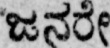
ಜನರೇ
